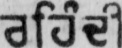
ਰਹਿੰਦੀ
